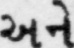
અને
